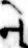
ને
